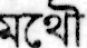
মথৌ
